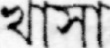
খাসা
